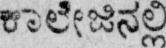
ಕಾಲೇಜಿನಲ್ಲಿ
